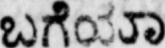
ಬಗೆಯಾ
